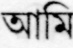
আমি
